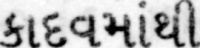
કાદવમાંથી
